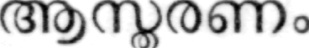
ആസ്തരണം
